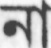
না
